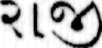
રાજી
